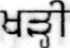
ਖੜ੍ਹੀ
